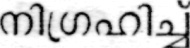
നിഗ്രഹിച്ച്
